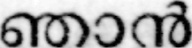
ഞാന്‍
